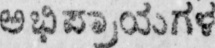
ಅಭಿಪ್ರಾಯಗಳ
